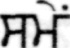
ਸਮੇਂ
